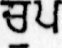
ਚੁਪ
